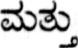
ಮತ್ತು
